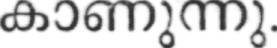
കാണുന്നു.
